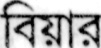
বিয়ার
